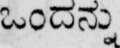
ಒಂದನ್ನು
